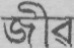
জীৱ
